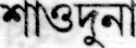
শাওদুনা
